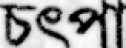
চৎপা
